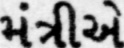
મંત્રીએ
